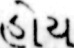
હોય
